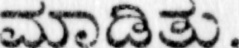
ಮಾಡಿತು.
